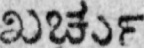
ಖರ್ಚು
